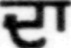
ਦਾ
